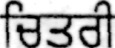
ਚਿਤਰੀ
